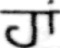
ਹਾਂ
